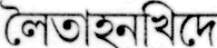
লৈতাহনখিদে
